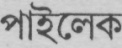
পাইলেক
